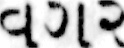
વગર
